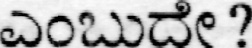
ಎಂಬುದೇ?
